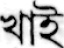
খাই
